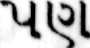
પણ
